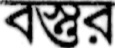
বস্তুর
